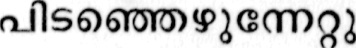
പിടഞ്ഞെഴുന്നേറ്റു
